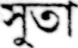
সুতা
